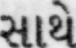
સાથે
